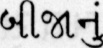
બીજાનું
